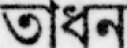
তাধন
